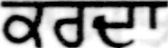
ਕਰਦਾ
